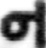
ન
